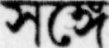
সঙ্গে
